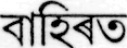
বাহিৰত
